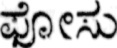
ಫೋಸು
